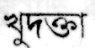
খুদক্তা
